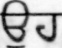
ਉਹ
